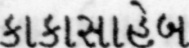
કાકાસાહેબ
